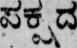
ಪಕ್ಷದ
